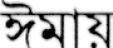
ঈমায়
